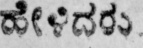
ಹೇಳಿದರು.
